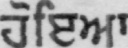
ਹੋਇਆ
